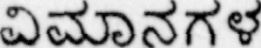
ವಿಮಾನಗಳ
